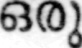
ഒരു
